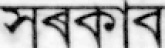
সৰকাব
